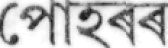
পোহৰৰ
